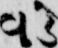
વડે
